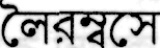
লৈরম্বসে
